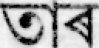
তাৰ
